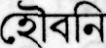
হৌবনি
